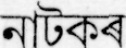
নাটকৰ
